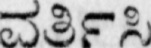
ವರ್ತಿಸಿ
